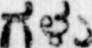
ಗಳು
